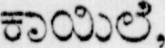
ಕಾಯಿಲೆ,
